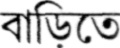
বাড়িতে
